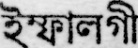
ইম্ফালগী
